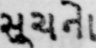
સૂચનો
